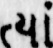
ત્યાં
